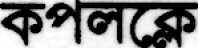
কপলক্লে
